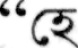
“হে
